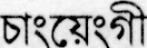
চাংয়েংগী
